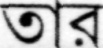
তার
